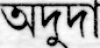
অদুদা
